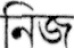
নিজ
